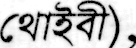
থোইবী),
